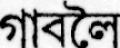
গাবলৈ
